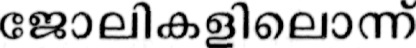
ജോലികളിലൊന്ന്
